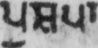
ਪੁਸ਼ਪਾ
